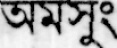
অমসুম
